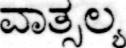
ವಾತ್ಸಲ್ಯ
